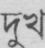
দুখ
